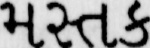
મસ્તક
